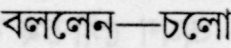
বললেন–চলো
